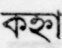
কহ্না
